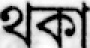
থকা
